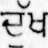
ਦੁੱਖ
